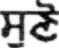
ਸੁਣੋ
